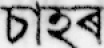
চাহৰ
